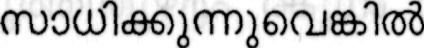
സാധിക്കുന്നുവെങ്കില്‍
